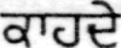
ਕਾਹਦੇ
